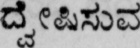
ದ್ವೇಷಿಸುವ
